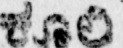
ಕೂಲಿ
